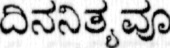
ದಿನನಿತ್ಯವೂ
